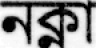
নক্না
